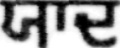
ਯਾਦ
